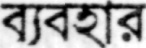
ব্যবহার
